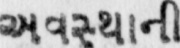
અવસ્થાની
